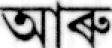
আৰু
